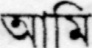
আমি
